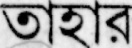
তাহার
